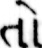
તો
